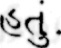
હતું.
